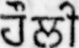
ਹੌਲੀ
